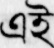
এই
